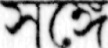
সঙ্গে
